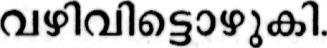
വഴിവിട്ടൊഴുകി.
